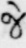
જે
